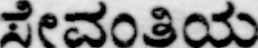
ಸೇವಂತಿಯ
